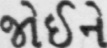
જોઈને
